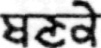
ਬਣਕੇ
